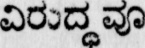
ವಿರುದ್ಧವೂ
